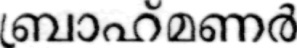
ബ്രാഹ്മണര്‍
